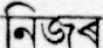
নিজৰ
